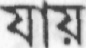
যায়
